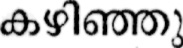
കഴിഞ്ഞു
